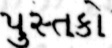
પુસ્તકો
